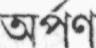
অর্পণ
